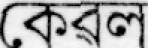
কেৱল
